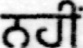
ਨਹੀਂ
